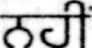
ਨਹੀਂ
